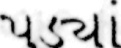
પડ્યાં
